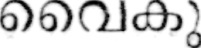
വൈകു
